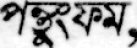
পন্থুংফম,
